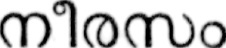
നീരസം
